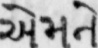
એમને
